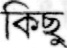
কিছু
